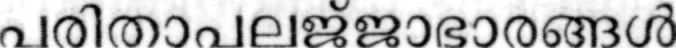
പരിതാപലജ്ജാഭാരങ്ങള്‍
